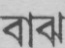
বাঝ
